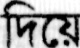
দিয়ে
